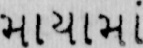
માયામાં
